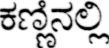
ಕಣ್ಣಿನಲ್ಲಿ
